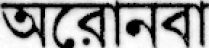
অরোনবা
